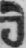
ਹੈ
